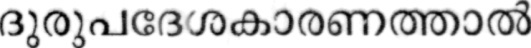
ദുരുപദേശകാരണത്താല്‍
